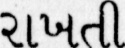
રાખતી
